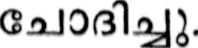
ചോദിച്ചു.
